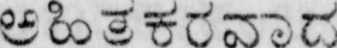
ಅಹಿತಕರವಾದ
